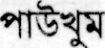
পাউখুম
